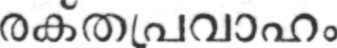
രക്തപ്രവാഹം
